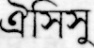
ঐসিসু
